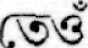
তেওঁ
